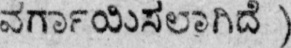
ವರ್ಗಾಯಿಸಲಾಗಿದೆ)
